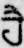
ਹੈ
